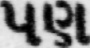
પણ
